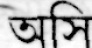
অসি
